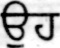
ਉਹ
